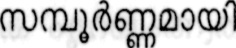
സമ്പൂര്‍ണ്ണമായി
